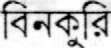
বিনকুরি
